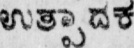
ಉತ್ಪಾದಕ
